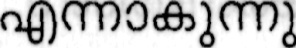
എന്നാകുന്നു
